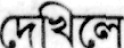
দেখিলে
